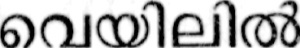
വെയിലില്‍
